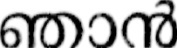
ഞാന്‍
